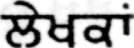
ਲੇਖਕਾਂ
